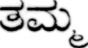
ತಮ್ಮ
